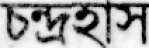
চন্দ্রহাস
